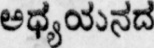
ಅಧ್ಯಯನದ
